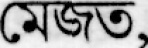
মেজত,
